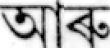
আৰু
